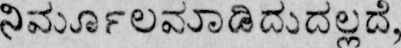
ನಿರ್ಮೂಲಮಾಡಿದುದಲ್ಲದೆ,
